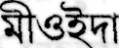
মীওইদা
